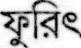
ফুরিৎ
